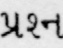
પ્રશ્ન
